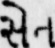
સેન
